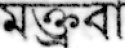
মক্ত্রবা
